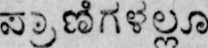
ಪ್ರಾಣಿಗಳಲ್ಲೂ
